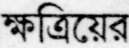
ক্ষত্রিয়ের
